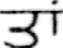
ਤਾਂ
